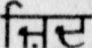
ਜ਼ਿਦ
